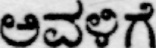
ಅವಳಿಗೆ
